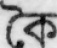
কৈ
